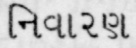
નિવારણ
